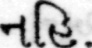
નહિ.
